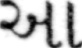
આ
